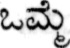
ಒಮ್ಮೆ
